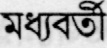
মধ্যবর্তী
